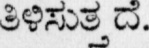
ತಿಳಿಸುತ್ತದೆ.
